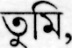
তুমি,
